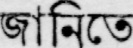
জানিতে
